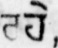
ਰਹੇ,
